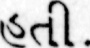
હતી.
